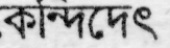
কেন্দিদেৎ
